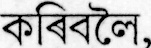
কৰিবলৈ,
